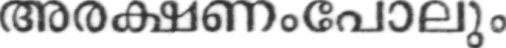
അരക്ഷണംപോലും
